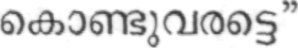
കൊണ്ടുവരട്ടെ”
